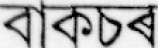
বাকচৰ
